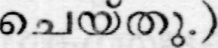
ചെയ്തു.)
